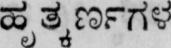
ಹೃತ್ಕರ್ಣಗಳ
